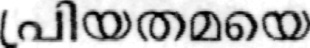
പ്രിയതമയെ
